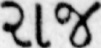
રાજ
